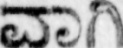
ವಾಗಿ
